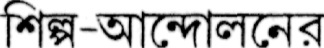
শিল্প-আন্দোলনের
